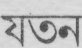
যতন
